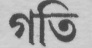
গতি
